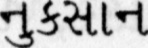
નુકસાન
